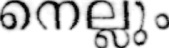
നെല്ലും
